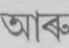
আৰু
